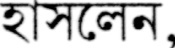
হাসলেন,
